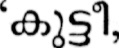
‘കുട്ടീ,
